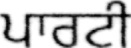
ਪਾਰਟੀ
